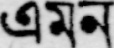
এমন
